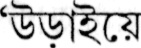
‘উড়াইয়ে
